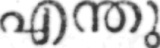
എന്തു
